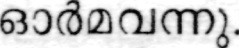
ഓര്‍മവന്നു.
